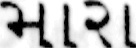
મારા
